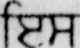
ਇਸ
